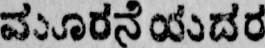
ಮೂರನೆಯದರ
